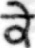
ਕੇ
